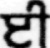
ਈ
